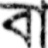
বা
